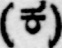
(ಕ)
